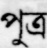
পুত্র
